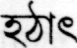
হঠাৎ
